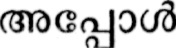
അപ്പോള്‍
